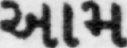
આમ
